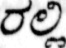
ರಲ್ಲಿ
